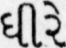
ધીરે
